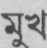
মুখ
